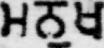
ਮਨੁਖ
